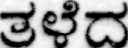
ತಳೆದ
